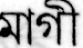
মাগী
